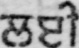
ਲਈ
